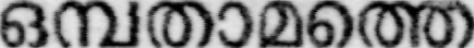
ഒമ്പതാമത്തെ
